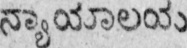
ನ್ಯಾಯಾಲಯ
